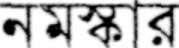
নমস্কার
